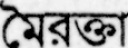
মৈরক্তা
